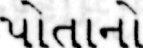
પોતાનો
